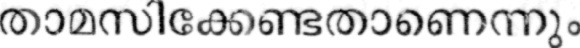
താമസിക്കേണ്ടതാണെന്നും
